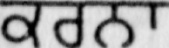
ਕਰਨਾ
